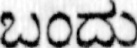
ಬಂದು
